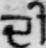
ਦੀ
